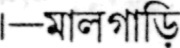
৷—মালগাড়ি
